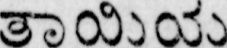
ತಾಯಿಯ
